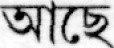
আছে
